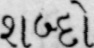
શબ્દો
